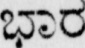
ಭಾರ
